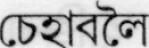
চেহাবলৈ
